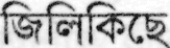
জিলিকিছে
